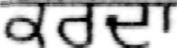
ਕਰਦਾ
